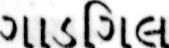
ગાડગિલ
